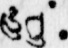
હતું.
